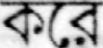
করে
